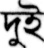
দুই
